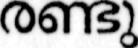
രണ്ടു
